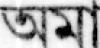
অমা
